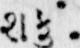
શકું.
